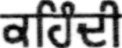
ਕਹਿੰਦੀ
